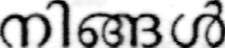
നിങ്ങള്‍
